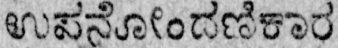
ಉಪನೋಂದಣಿಕಾರ
